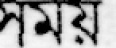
সময়
